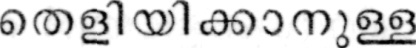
തെളിയിക്കാനുള്ള
